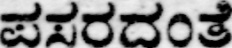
ಪಸರದಂತೆ
